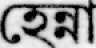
হেন্না
